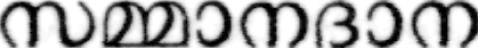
സമ്മാനദാന
